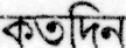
কতদিন
